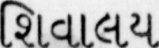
શિવાલય
